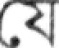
যে
